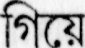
গিয়ে
